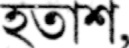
হতাশ,
